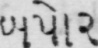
બપોર
